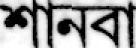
শানবা
